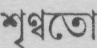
শৃণ্বতো
